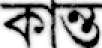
কান্ত
